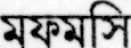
মফমসি
